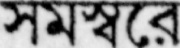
সমস্বরে
